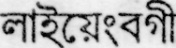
লাইয়েংবগী
